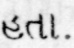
હતા.
